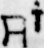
ਸਾਂ
